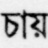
চায়
